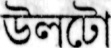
উলটো
